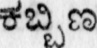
ಕಬ್ಬಿಣ
